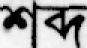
শব্দ
